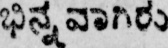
ಭಿನ್ನವಾಗಿರು
